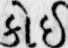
કોઈ
